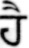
ਹੈ
